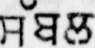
ਸੱਬਲ
